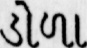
ડોળા
